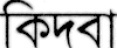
কিদবা
